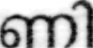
ണി
